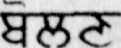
ਬੋਲਣ
